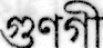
গুণগী
